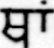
ਥਾਂ
